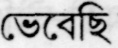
ভেবেছি
